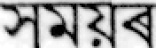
সময়ৰ
